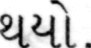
થયો.
